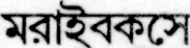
মরাইবকসে
